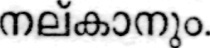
നല്കാനും.
